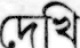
দেখি
